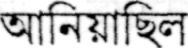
আনিয়াছিল
